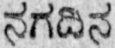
ನಗದಿನ
